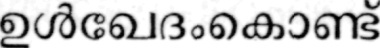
ഉള്‍ഖേദംകൊണ്ട്
